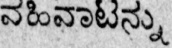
ವಾಹಿವಾಟನ್ನು
